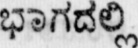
ಭಾಗದಲ್ಲಿ
